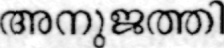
അനുജത്തി
